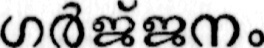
ഗര്‍ജ്ജനം
